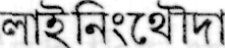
লাইনিংথৌদা
